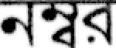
নম্বর
